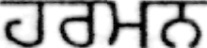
ਹਰਮਨ
